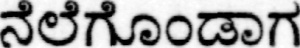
ನೆಲೆಗೊಂಡಾಗ
